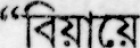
"বিয়ায়ে
